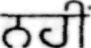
ਨਹੀਂ
